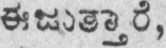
ಈಜುತ್ತಾರೆ,
